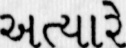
અત્યારે
